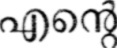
എന്റെ
